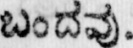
ಬಂದವು.
